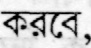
করবে,
